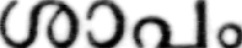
ശാപം
